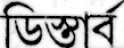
ডিস্তার্ব
